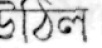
উঠিল
